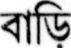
বাড়ি
